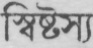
স্বিষ্টস্য
